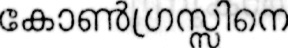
കോണ്‍ഗ്രസ്സിനെ
